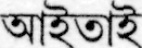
আইতাই
